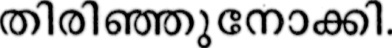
തിരിഞ്ഞുനോക്കി.
